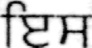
ਇਸ
